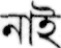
নাই
